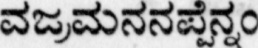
ವಜ್ರಮನನಪ್ಪೆನ್ನಂ
